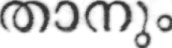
താനും
